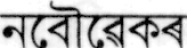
নবৌৱেকৰ
